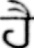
ਹੈ
